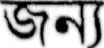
জন্য
